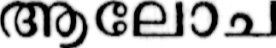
ആലോച
